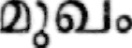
മുഖം
